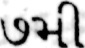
૭મી
